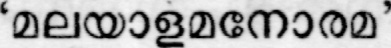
‘മലയാളമനോരമ’
